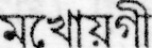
মখোয়গী
